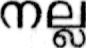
നല്ല
